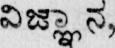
ವಿಜ್ಞಾನ,
